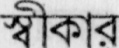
স্বীকার
